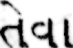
તેવા
